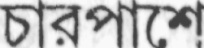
চারপাশে
